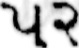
પર
